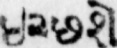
ઇચ્છશે
